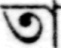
তা
